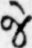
જે
